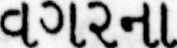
વગરના
